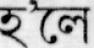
হ'লে
